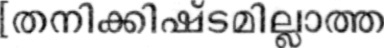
"തനിക്കിഷ്ടമില്ലാത്ത
